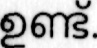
ഉണ്ട്.
